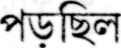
পড়ছিল
